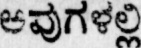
ಅವುಗಳಲ್ಲಿ
